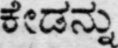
ಕೇಡನ್ನು
